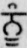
ਨੂੰ
